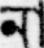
না
